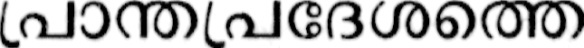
പ്രാന്തപ്രദേശത്തെ
